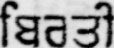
ਬਿਰਤੀ
